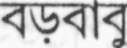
বড়বাবু
